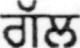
ਗੱਲ
